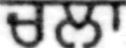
ਚਲਾ
